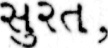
સુરત,
